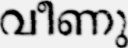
വീണു
